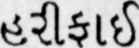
હરીફાઈ
